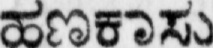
ಹಣಕಾಸು
